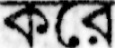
করে
